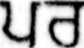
ਪਰ
